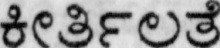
ಕೀರ್ತಿಲತೆ
